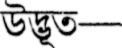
উদ্ভূত-
